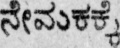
ನೇಮಕಕ್ಕೆ
